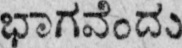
ಭಾಗವೆಂದು
